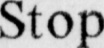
Stop
